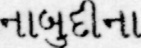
નાબુદીના
